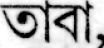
তাবা,
